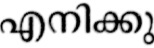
എനിക്കു
